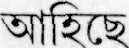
আহিছে
